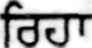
ਰਿਹਾ
